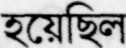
হয়েছিল
